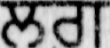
ਲਗ
